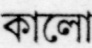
কালো
